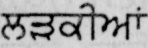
ਲੜਕੀਆਂ
